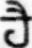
ਹੈ
